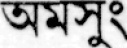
অমসুং
